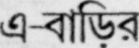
এ-বাড়ির
